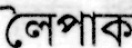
লৈপাক
